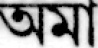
অমা
